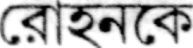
রোহনকে
